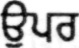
ਉਪਰ
